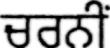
ਚਰਨੀਂ
